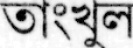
তাংখুল
